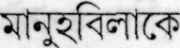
মানুহবিলাকে
